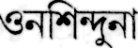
ওনশিন্দুনা
